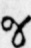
જ
